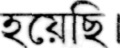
হয়েছি।
